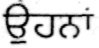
ਉਹਨਾਂ
